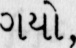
ગયો,
